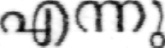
എന്നു
